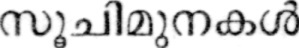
സൂചിമുനകള്‍
